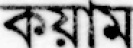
কয়াম
